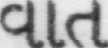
વાત
